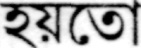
হয়তো
